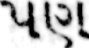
પણ
